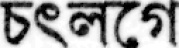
চৎলগে
